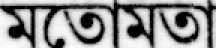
মতোমতা
